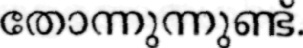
തോന്നുന്നുണ്ട്.
